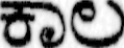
ಕಾಲ
